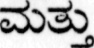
ಮತ್ತು
